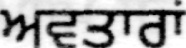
ਅਵਤਾਰਾਂ
